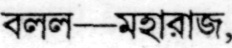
বলল–মহারাজ,
